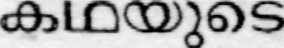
കഥയുടെ
